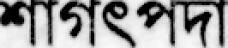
শাগৎপদা
